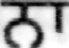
ਨਾ
